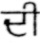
ਦੀ
